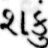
શકું
